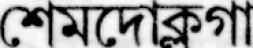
শেমদোক্লগা
